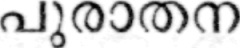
പുരാതന
